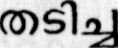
തടിച്ച
